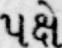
પક્ષે
